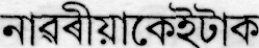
নাৱৰীয়াকেইটাক
